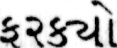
ફરક્યો
